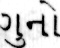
ગુનો
